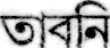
তাবনি
